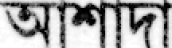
আশাদা
